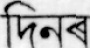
দিনৰ
